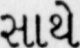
સાથે
